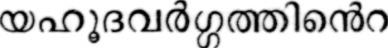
യഹൂദവര്‍ഗ്ഗത്തിന്റെ
